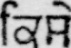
ਕਿਸੇ
